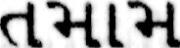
તમામ
